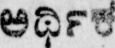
ಆರ್ಥಿಕ
